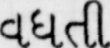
વધતી
